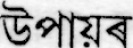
উপায়ৰ
